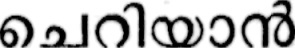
ചെറിയാന്‍
